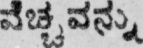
ವೆಚ್ಚವನ್ನು
